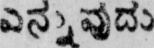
ಎನ್ನುವುದು
